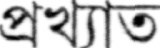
প্রখ্যাত
